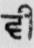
ਵੀ
